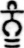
ਨੂੰ
